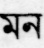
মন
